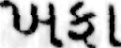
ખફા
